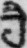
ਹੈ
